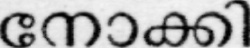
നോക്കി
